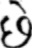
છે
